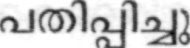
പതിപ്പിച്ചു
